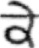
ਕੇ
